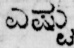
ಎಷ್ಟು
